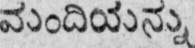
ಮಂದಿಯನ್ನು
